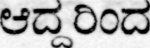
ಆದ್ದರಿಂದ
